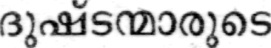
ദുഷ്ടന്മാരുടെ
